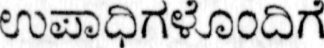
ಉಪಾಧಿಗಳೊಂದಿಗೆ
